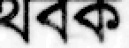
থবক
